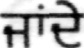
ਜਾਂਦੇ
